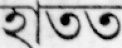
হাতত
